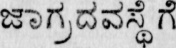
ಜಾಗ್ರದವಸ್ಥೆಗೆ
